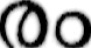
രം
